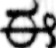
ಈ
